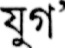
যুগ'
